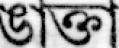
ঙাক্তা
